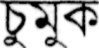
চুমুক
